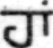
ਹਾਂ
